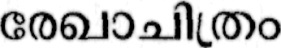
രേഖാചിത്രം
